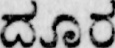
ದೂರ
